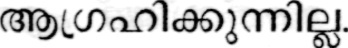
ആഗ്രഹിക്കുന്നില്ല.
